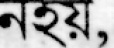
নহয়,
